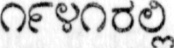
೧೯೪೧ರಲ್ಲಿ
